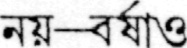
নয়—বর্ষাও
